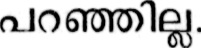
പറഞ്ഞില്ല.
